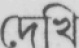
দেখি
